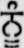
ਨੂੰ
